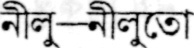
নীলু—নীলুতো
